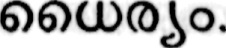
ധൈര്യം.
